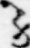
કે
